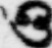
ও
